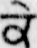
ਕੇ
